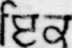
ਇਕ
